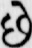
છે
